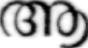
ആ
